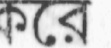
করে
